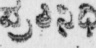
ಪ್ರತಿನಿಧಿ
